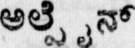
ಅಲ್ಫೈನ್
